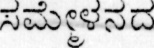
ಸಮ್ಮೇಳನದ
